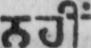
ਨਹੀਂ
